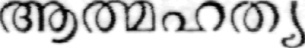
ആത്മഹത്യ
